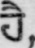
ਹੈ,
